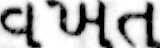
વખત
